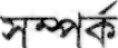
সম্পর্ক
